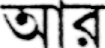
আর
